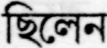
ছিলেন
